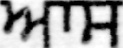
ਆਸ
